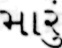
મારું
